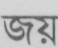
জয়
